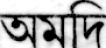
অমদি
